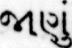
જાણું
